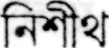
নিশীথ
